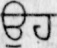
ਉਹ
